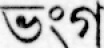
ভংগ
